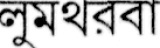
লুমথরবা
